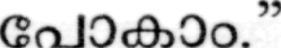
പോകാം."
